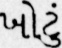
ખોટું
